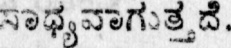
ಸಾಧ್ಯವಾಗುತ್ತದೆ.
